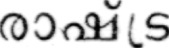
രാഷ്ട്ര
